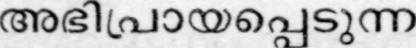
അഭിപ്രായപ്പെടുന്ന
